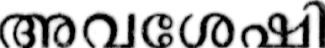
അവശേഷി
